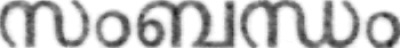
സംബന്ധം
